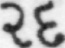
રદ
